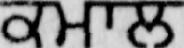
ਕਮਾਲ
